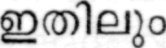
ഇതിലും
